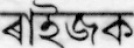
ৰাইজক
